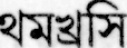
থমখ্রসি
